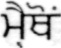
ਮੈਥੋਂ
